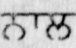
ਨਾਲ
